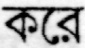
করে
